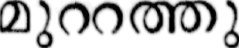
മുററത്തു
